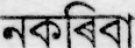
নকৰিবা
